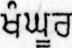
ਖੰਘੂਰ
